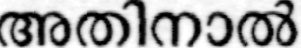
അതിനാല്‍
